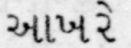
આખરે
